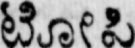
ಟೋಪಿ
